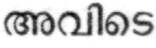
അവിടെ
